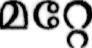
മറ്റേ
